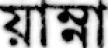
য়াম্না
